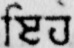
ਇਹ
